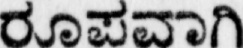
ರೂಪವಾಗಿ
